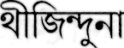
থীজিন্দুনা
